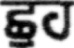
ਛੁਹ
